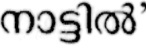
നാട്ടില്‍'
